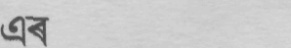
এৰ
